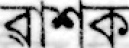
ৱাশক
